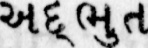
અદ્ભુત
